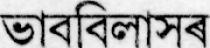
ভাববিলাসৰ
